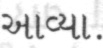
આવ્યા.
